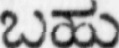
ಬಹು
